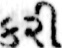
કરી
